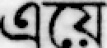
এয়ে
